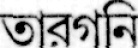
তারগনি
